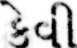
કેવી
